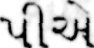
પીએ
